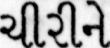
ચીરીને
